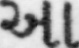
આ
